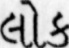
લોક
